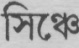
সিঞ্চে
